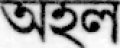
অহল
